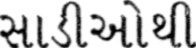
સાડીઓથી
